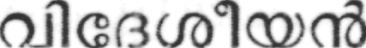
വിദേശീയന്‍
